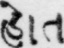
હોત
